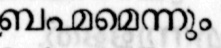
ബ്രഹ്മമെന്നും
